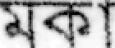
মকা
